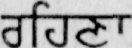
ਰਹਿਣਾ
